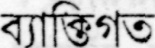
ব্যাক্তিগত
